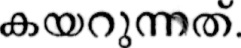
കയറുന്നത്.
